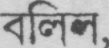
বলিল,
